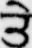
ਤੇ
